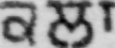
ਕਲਾ
